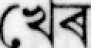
খেৰ
